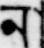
না
